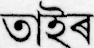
তাইৰ
